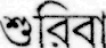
শুরিবা
